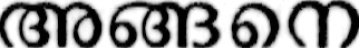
അങ്ങനെ
